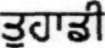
ਤੁਹਾਡੀ
